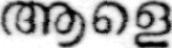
ആളെ
